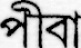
পীবা
